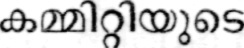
കമ്മിറ്റിയുടെ
